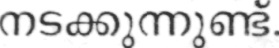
നടക്കുന്നുണ്ട്.
